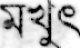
মখুৎ
